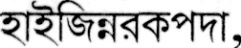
হাইজিন্নরকপদা,
